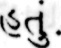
હતું.
